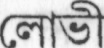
লোভী
